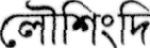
লৌশিংদি
